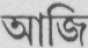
আজি
